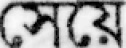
সেয়ে
